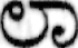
ಲಾ
